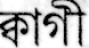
ক্বাগী
